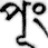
পূং
